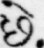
છે.
